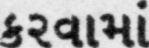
કરવામાં
